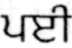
ਪਈ
